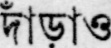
দাঁড়াও
